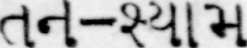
તન-શ્યામ
